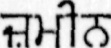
ਜ਼ਮੀਨ
